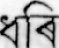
ধৰি
